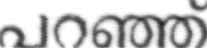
പറഞ്ഞ്
